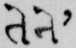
તેને'
